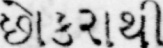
છોકરાથી
